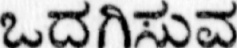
ಒದಗಿಸುವ
